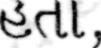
હતા,
